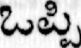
ಒಪ್ಪಿ
